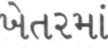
ખેતરમાં
